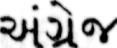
અંગ્રેજ
